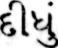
દીધું
